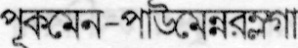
পূকমেন-পাউমেন্নরম্লগা
